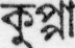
কুপ্পা
